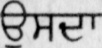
ਉਸਦਾ
